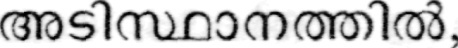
അടിസ്ഥാനത്തില്‍,
